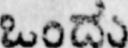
ಒಂದು
